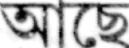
আছে
